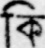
কি
